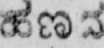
ಹಣದ
